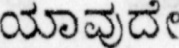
ಯಾವುದೇ
